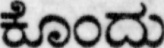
ಕೊಂದು
